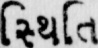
સ્થિતિ
